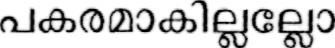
പകരമാകില്ലല്ലോ
